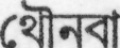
থৌনবা
